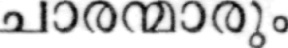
ചാരന്മാരും
